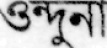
ওন্দুনা
